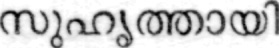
സുഹൃത്തായി
